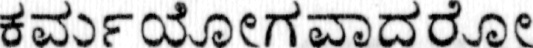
ಕರ್ಮಯೋಗವಾದರೋ
